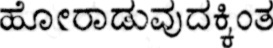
ಹೋರಾಡುವುದಕ್ಕಿಂತ
